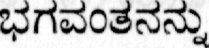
ಭಗವಂತನನ್ನು
